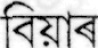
বিয়াৰ
